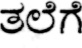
ತಲೆಗೆ
